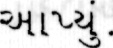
આપ્યું.
